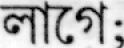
লাগে;
